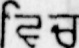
ਵਿਚ
